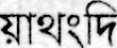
য়াথংদি
